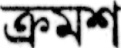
ক্রমশ
